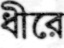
ধীরে
